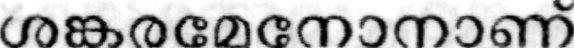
ശങ്കരമേനോനാണ്
